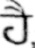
ਹੈ,
